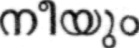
നീയും
